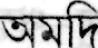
অমদি
